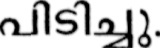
പിടിച്ചു.
